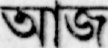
আজ
